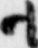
ન
